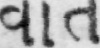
વાત
